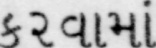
કરવામાં
